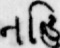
નહિ
